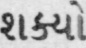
શક્યો
